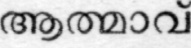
ആത്മാവ്
